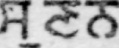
ਸੁਣਨ
